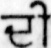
ਦੀ
